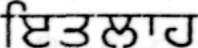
ਇਤਲਾਹ
